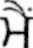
ਮੈਂ
